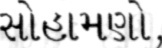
સોહામણો,
